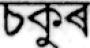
চকুৰ
